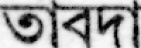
তাবদা
